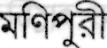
মণিপুরী
